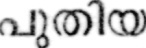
പുതിയ
